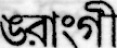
ঙরাংগী
